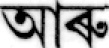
আৰু
